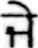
ਜੇ
